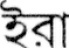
ইরা
